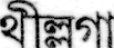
থীল্লগা
